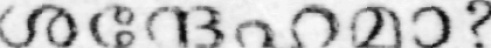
ശന്ദേഹമാ?
